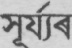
সূৰ্য্যৰ
